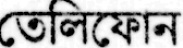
তেলিফোন
